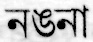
নঙনা
